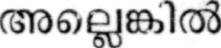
അല്ലെങ്കില്‍
